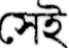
সেই
